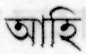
আহি
